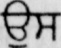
ਉਸ
